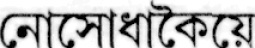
নোসোধাকৈয়ে
